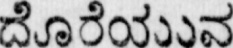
ದೊರೆಯುವ
